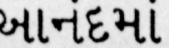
આનંદમાં
